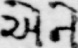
એને
